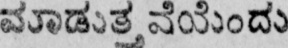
ಮಾಡುತ್ತವೆಯೆಂದು
